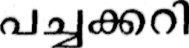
പച്ചക്കറി
